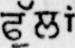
ਫੁੱਲਾਂ
